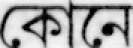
কোনে
